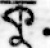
কু.
